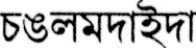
চঙলমদাইদা
